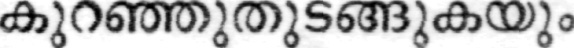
കുറഞ്ഞുതുടങ്ങുകയും
